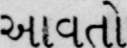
આવતો
